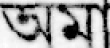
অমা
